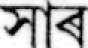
সাৰ
